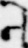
ને
